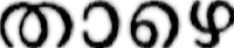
താഴെ
